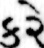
કરે
